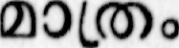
മാത്രം
